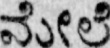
ಮೇಲೆ
